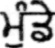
ਮੁੰਡੇ
